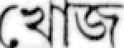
খোজ
